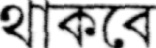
থাকবে
